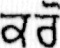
ਕਰੋ
